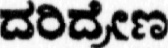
ದರಿದ್ರೇಣ
